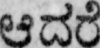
ಆದರೆ
